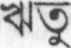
ঋতু
